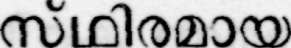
സ്ഥിരമായ
